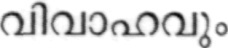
വിവാഹവും
